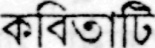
কবিতাটি
